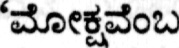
‘ಮೋಕ್ಷವೆಂಬ
